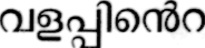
വളപ്പിന്റെ
